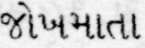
જોખમાતા
